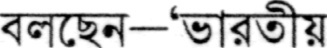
বলছেন–‘ভারতীয়
